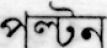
পল্টন
